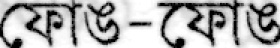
ফোঙ-ফোঙ
